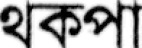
থকপা
